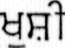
ਖੁਸ਼ੀ
